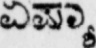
ಏಷ್ಯಾ
